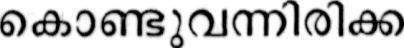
കൊണ്ടുവന്നിരിക്ക
